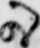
જે
